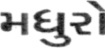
મધુરો
